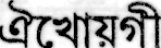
ঐখোয়গী
